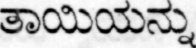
ತಾಯಿಯನ್ನು
